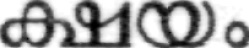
ക്ഷയം
